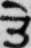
ਤੇ
